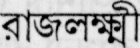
রাজলক্ষ্মী
